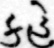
કહે
